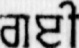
ਗਈ
